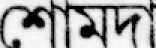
শোমদা
